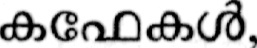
കഫേകള്‍,
